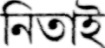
নিতাই
